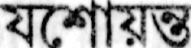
যশোয়ন্ত
